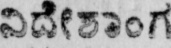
ವಿದೇಶಾಂಗ
